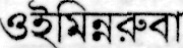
ওইমিন্নরুবা
